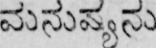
ಮನುಷ್ಯನು
